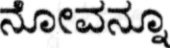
ನೋವನ್ನೂ
